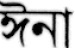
ঈনা
